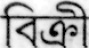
বিক্রী
